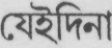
যেইদিনা
